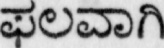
ಫಲವಾಗಿ
